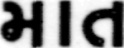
માત
